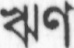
ঋণ
